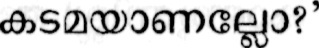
കടമയാണല്ലോ?’
